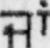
ਜਾਂ
